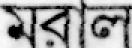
মরাল
